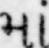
માં
